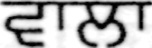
ਵਾਲਾ
